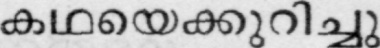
കഥയെക്കുറിച്ചു
